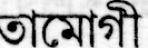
তামোগী
